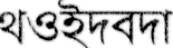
থওইদবদা
